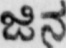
ಜಿನ
